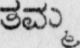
ತಮ್ಮ
